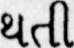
થતી
